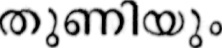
തുണിയും
